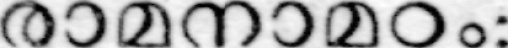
രാമനാമഠം:
